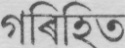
গৰিহিত
